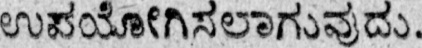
ಉಪಯೋಗಿಸಲಾಗುವುದು.
